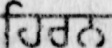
ਹਿਰਨ
